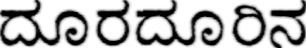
ದೂರದೂರಿನ
